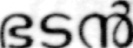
ഭടന്‍
